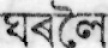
ঘৰলৈ
